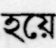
হয়ে
